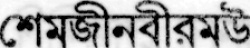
শেমজীনবীরমউ
